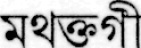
মথক্তগী
